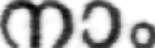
നാം
